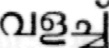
വളച്ച്
